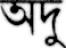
অদু
